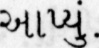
આપ્યું.
